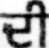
ਦੀ
